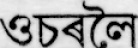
ওচৰলৈ
